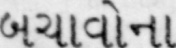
બચાવોના
